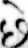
છે
